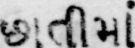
છાતીમાં
